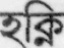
হক্নি
